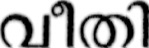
വീതി
